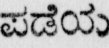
ಪಡೆಯ
